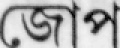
জোপ
